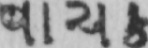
વાચક
